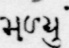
મળ્યું
